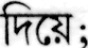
দিয়ে;
